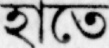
হাতে
